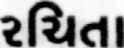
રચિતા
